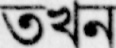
তখন
